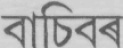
বাচিবৰ
